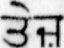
ਤੇਜ਼
